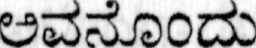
ಅವನೊಂದು
